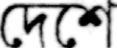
দেশে
